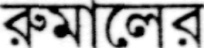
রুমালের
